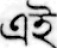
এই
